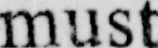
must
